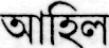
আহিল
